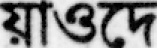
য়াওদে
